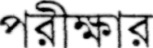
পরীক্ষার
